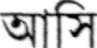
আসি
